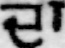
ਦਾ
